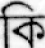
কি
